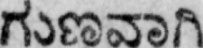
ಗುಣವಾಗಿ
